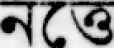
নত্তে
